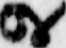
જ
